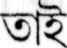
তাই
